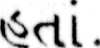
હતાં.
